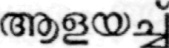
ആളയച്ച്
